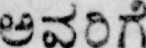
ಅವರಿಗೆ
